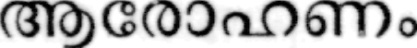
ആരോഹണം
